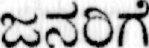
ಜನರಿಗೆ
